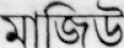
মাজিউ
